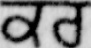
ਕਰ
